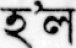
হ'ল
